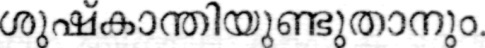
ശുഷ്കാന്തിയുണ്ടുതാനും.
